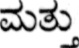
ಮತ್ತು
